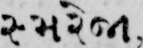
સ્મરેજા,
